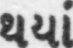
થયાં
